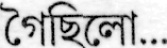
গৈছিলো...
